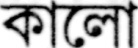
কালো
